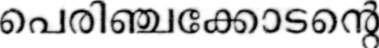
പെരിഞ്ചക്കോടന്റെ
